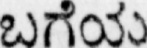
ಬಗೆಯ
